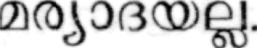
മര്യാദയല്ല.
